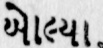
બોલ્યા,
